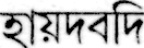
হায়দবদি
